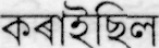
কৰাইছিল
